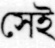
সেই
